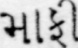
માફી
